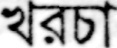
খরচা
